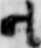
ન
